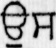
ਉਸ
